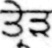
ਤ੍ਰੇੜ
